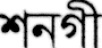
শনগী
